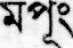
মপূং
